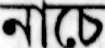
নাচে
